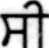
ਸੀ
